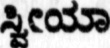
ಸ್ವೀಯಾ
